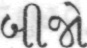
બીજો
